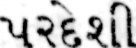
પરદેશી
